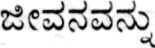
ಜೀವನವನ್ನು
